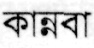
কান্নবা
